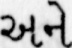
અને
